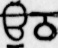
ਉਠ
